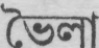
ভৈলা
